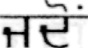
ਜਦੋਂ
